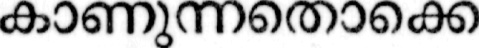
കാണുന്നതൊക്കെ
